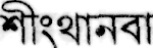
শীংথানবা
